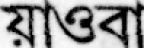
য়াওবা
